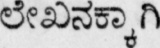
ಲೇಖನಕ್ಕಾಗಿ
